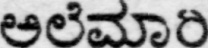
ಅಲೆಮಾರಿ
